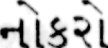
નોકરો
